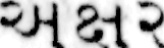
અક્ષર
